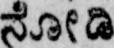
ನೋಡಿ
